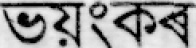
ভয়ংকৰ
